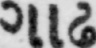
ગાઢ
